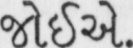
જોઈએ.
